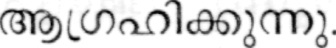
ആഗ്രഹിക്കുന്നു.
